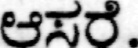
ಆಸರೆ.
